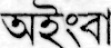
অইংবা
